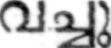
വച്ചു
